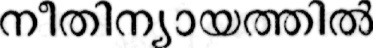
നീതിന്യായത്തില്‍
